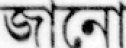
জানো
